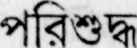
পরিশুদ্ধ
